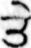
ਤੇ
